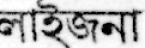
লাইজনা
